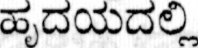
ಹೃದಯದಲ್ಲಿ
